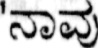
‘ನಾವು
